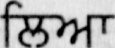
ਲਿਆ
